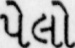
પેલો
